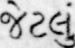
જેટલું
